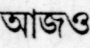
আজও
